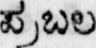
ಪ್ರಬಲ
